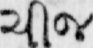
ચીજ
